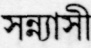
সন্ন্যাসী
